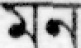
মন
